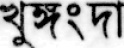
খু্ঙ্গংদা
